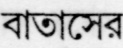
বাতাসের
